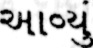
આવ્યું
